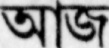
আজ
